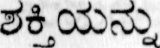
ಶಕ್ತಿಯನ್ನು
